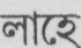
লাহে
